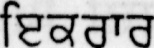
ਇਕਰਾਰ
